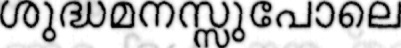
ശുദ്ധമനസ്സുപോലെ
